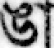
ঙা
